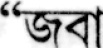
"জবা
